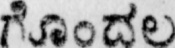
ಗೊಂದಲ
